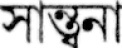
সান্ত্বনা
